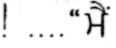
!..'ਮੈਂ
